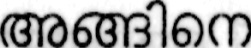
അങ്ങിനെ
